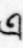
এ
